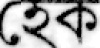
হেক
